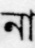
না
